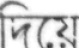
দিয়ে
